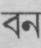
বন
